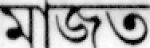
মাজত
